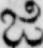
ಜಿ
